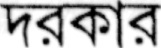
দরকার
